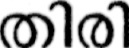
തിരി
